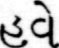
હવે
